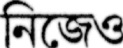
নিজেও
